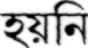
হয়নি
